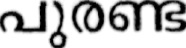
പുരണ്ട
